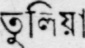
তুলিয়া
